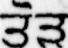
ਤੋੜ
